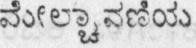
ಮೇಲ್ಚಾವಣಿಯ
